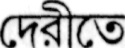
দেরীতে
